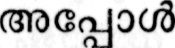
അപ്പോള്‍
